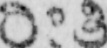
ರೀತಿ
